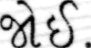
જોઈ.
